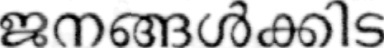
ജനങ്ങള്‍ക്കിട
